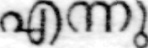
എന്നു
